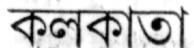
কলকাতা
